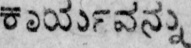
ಕಾರ್ಯವನ್ನು
